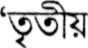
'তৃতীয়
